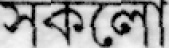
সকলো
